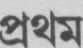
প্ৰথম
